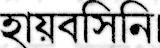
হায়বসিনি।
